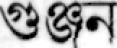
গুঞ্জন
